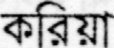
করিয়া
